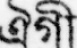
ঐগী
